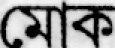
মোক
